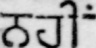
ਨਹੀਂ
